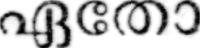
ഏതോ
